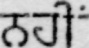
ਨਹੀਂ
